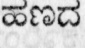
ಹಣದ
